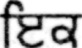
ਇਕ
